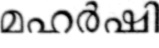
മഹര്‍ഷി
